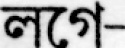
লগে-
